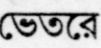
ভেতরে
